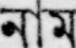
নাম
